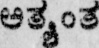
ಅತ್ಯಂತ
